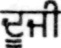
ਦੂਜੀ
